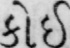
કોઈ
